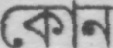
কোন
